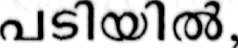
പടിയില്‍,
